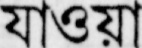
যাওয়া
